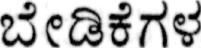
ಬೇಡಿಕೆಗಳ
